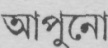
আপুনো
